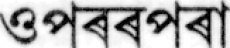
ওপৰৰপৰা
